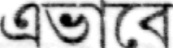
এভাবে
